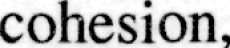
cohesion,
